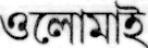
ওলোমাই
